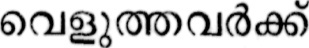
വെളുത്തവര്‍ക്ക്
